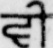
ਵੀ
